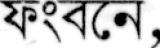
ফংবনে,
